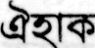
ঐহাক
